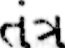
તંત્ર
